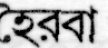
হৈরবা
